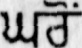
ਘਰੋਂ
